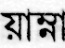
য়াম্না
